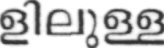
ളിലുള്ള
